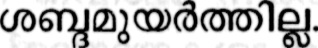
ശബ്ദമുയര്‍ത്തില്ല.
